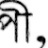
পী,
